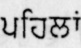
ਪਹਿਲਾਂ
